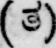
(ತ)
